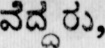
ವೆದ್ದರು,
